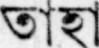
তাহা
